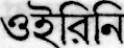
ওইরিনি
